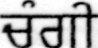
ਚੰਗੀ
